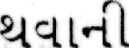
થવાની
